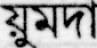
য়ুমদা
